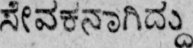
ಸೇವಕನಾಗಿದ್ದು
